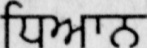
ਧਿਆਨ
